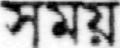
সময়
